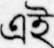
এই
